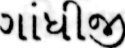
ગાંધીજી
